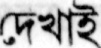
দেখাই
